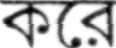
করে
